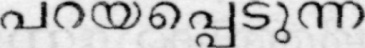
പറയപ്പെടുന്ന
